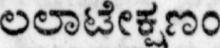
ಲಲಾಟೇಕ್ಷಣಂ
